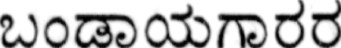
ಬಂಡಾಯಗಾರರ
